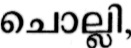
ചൊല്ലി,
